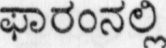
ಫಾರಂನಲ್ಲಿ
